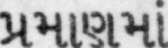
પ્રમાણમાં
